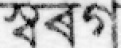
স্বৰগ
